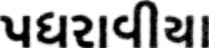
પધરાવીયા
